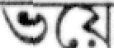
ভয়ে
